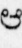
ಆ
